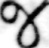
જ
